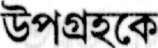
উপগ্রহকে
